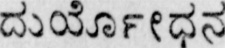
ದುರ್ಯೋಧನ
